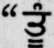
''ਤੂੰ
